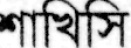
শাখিসি
